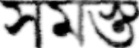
সমস্ত
